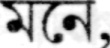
মনে,
